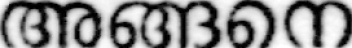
അങ്ങനെ
